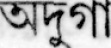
অদুগা
